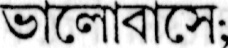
ভালোবাসে;
